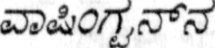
ವಾಷಿಂಗ್ಟನ್‌ನ
